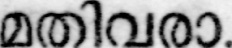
മതിവരാ.
